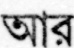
আর
